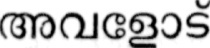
അവളോട്
